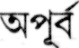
অপূর্ব
